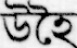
উহৈ
